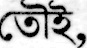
তৌই,
